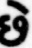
છે
